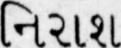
નિરાશ
